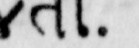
જતા.
